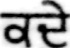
ਕਦੇ
